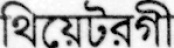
থিয়েটরগী
